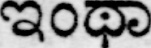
ಇಂಥಾ
